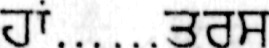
ਹਾ.....ਤਰਸ
